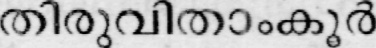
തിരുവിതാംകൂര്‍
